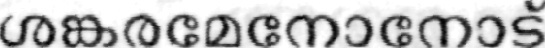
ശങ്കരമേനോനോട്
